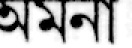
অমনা
